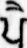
ਪੈ
